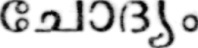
ചോദ്യം
